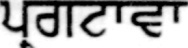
ਪ੍ਰਗਟਾਵਾ
